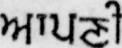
ਆਪਣੀ
